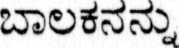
ಬಾಲಕನನ್ನು
